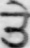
ਤੇ
